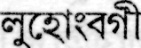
লুহোংবগী
